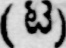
(ಟ)
